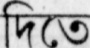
দিতে
